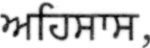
ਅਹਿਸਾਸ,
